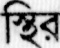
স্থির
